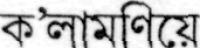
ক'লামণিয়ে
